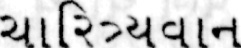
ચારિત્ર્યવાન
